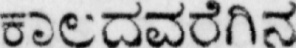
ಕಾಲದವರೆಗಿನ
